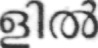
ളില്‍
